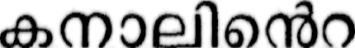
കനാലിന്റെ
